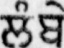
ਲੰਬੇ
